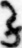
કે
